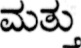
ಮತ್ತು
